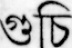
গুচি
